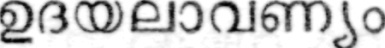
ഉദയലാവണ്യം
